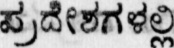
ಪ್ರದೇಶಗಳಲ್ಲಿ
